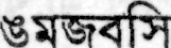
ঙমজবসি
